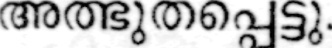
അത്ഭുതപ്പെട്ടു.
